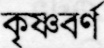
কৃষ্ণবর্ণ
